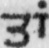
ਤਾਂ
